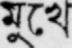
মুখে
